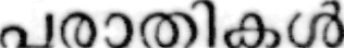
പരാതികള്‍
